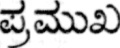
ಪ್ರಮುಖ
